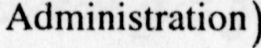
Administration)
